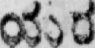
ಯರ
